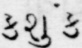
કશુંક
